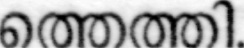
ത്തെത്തി.
